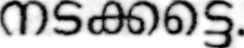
നടക്കട്ടെ.
